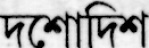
দশোদিশ
